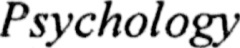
Psychology
